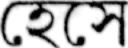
হেসে
